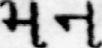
મન
